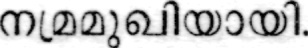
നമ്രമുഖിയായി.
